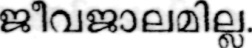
ജീവജാലമില്ല.
